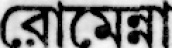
রোমেন্না
